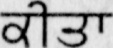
ਕੀਤਾ
